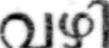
വഴി
